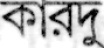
কারদু
